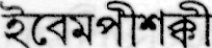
ইবেমপীশক্কী
